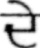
ਦੇ
